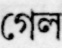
গেল
